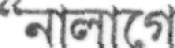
"নালাগে
